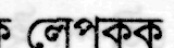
হংলকপনি
